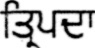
ਤ੍ਰਿਪਦਾ
